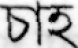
চাহ
